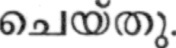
ചെയ്തു.
